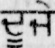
ਦੂਜੇ
